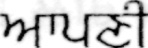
ਆਪਣੀ
